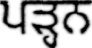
ਪੜ੍ਹਨ
